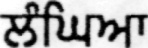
ਲੰਘਿਆ
